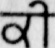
ਕੀ
